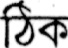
ঠিক
